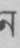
ন
